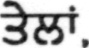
ਤੇਲਾਂ,
